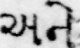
અને
